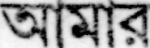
আমার
